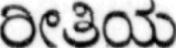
ರೀತಿಯ
